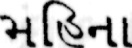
મહિના
